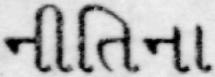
નીતિના
